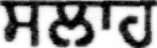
ਸਲਾਹ
